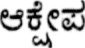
ಆಕ್ಷೇಪ
